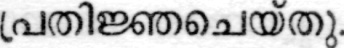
പ്രതിജ്ഞചെയ്തു.
